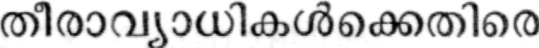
തീരാവ്യാധികള്‍ക്കെതിരെ
